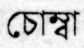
চোম্বা
